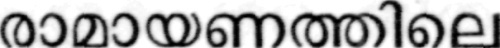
രാമായണത്തിലെ
